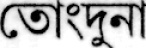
তোংদুনা
